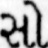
સો
